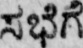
ಸಭೆಗೆ
